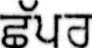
ਛੱਪਰ
